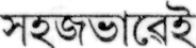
সহজভাৱেই
